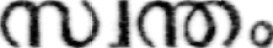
സ്വന്തം
